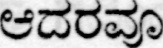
ಆದರವೂ
